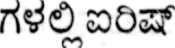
ಗಳಲ್ಲಿಐರಿಷ್
